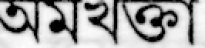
অমখক্তা
